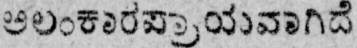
ಅಲಂಕಾರಪ್ರಾಯವಾಗಿದೆ
